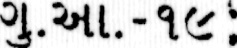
ગુ.આ.-૧૯
